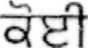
ਕੋਈ
